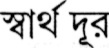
স্বার্থ দূর
